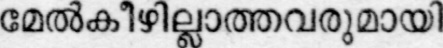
മേല്‍കീഴില്ലാത്തവരുമായി
